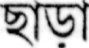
ছাড়া
